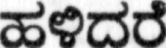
ಹಳಿದರೆ
